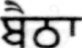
ਬੈਠਾ
